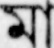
মা
